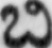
ಬಿ
